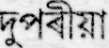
দুপৰীয়া
